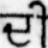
ਦੀ
